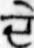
ਦੇ
